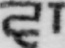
ਵਾ
